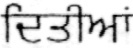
ਦਿਤੀਆਂ
